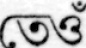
তেওঁ
